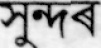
সুন্দৰ
